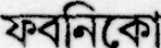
ফবনিকো
